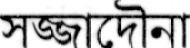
সজ্জাদৌনা
